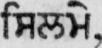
ਸਿਲਮੇ,
